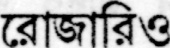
রোজারিও
